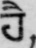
ਹੈ,
